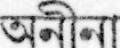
অনীনা
